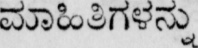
ಮಾಹಿತಿಗಳನ್ನು
